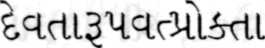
દેવતારૂપવત્પ્રોક્તા
